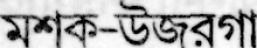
মশক-উজরগা
